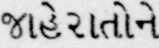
જાહેરાતોને
